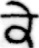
ਕੇ
